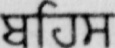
ਬਹਿਸ
